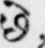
છે,
